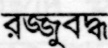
রজ্জুবদ্ধ
